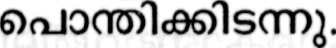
പൊന്തിക്കിടന്നു.
